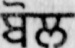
ਬੋਲ
